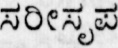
ಸರೀಸೃಪ
